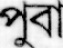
পুবা
